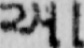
આ
